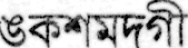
ঙকশমদগী
